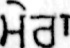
ਮੇਰਾ
